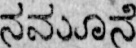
ನಮೂನೆ
